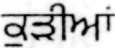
ਕੁੜੀਆਂ
